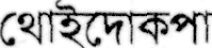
থোইদোকপা
